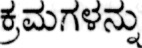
ಕ್ರಮಗಳನ್ನು
